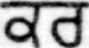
ਕਰ
